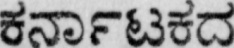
ಕರ್ನಾಟಕದ
